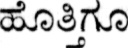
ಹೊತ್ತಿಗೂ
